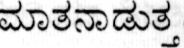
ಮಾತನಾಡುತ್ತ
